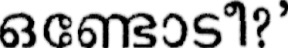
ഒണ്ടോടീ?’
